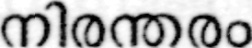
നിരന്തരം
